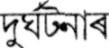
দুর্ঘটনাৰ
